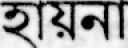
হায়না
